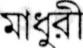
মাধুরী
